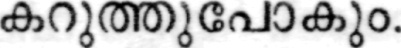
കറുത്തുപോകും.
